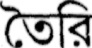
তৈরি
